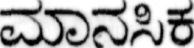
ಮಾನಸಿಕ
